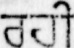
ਰਹੀ
